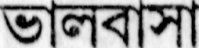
ভালবাসা
